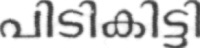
പിടികിട്ടി
